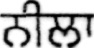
ਨੀਲਾ
